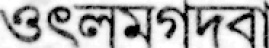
ওৎলমগদবা
